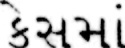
કેસમાં
